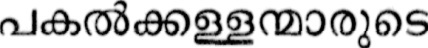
പകല്‍ക്കള്ളന്മാരുടെ
